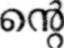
ന്റെ
